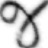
જ
